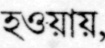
হওয়ায়,
